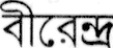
বীরেন্দ্র
